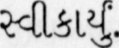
સ્વીકાર્યું.
